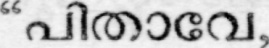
"പിതാവേ,
